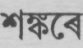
শঙ্কৰে
